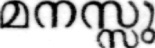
മനസ്സു
